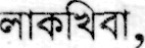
লাকখিবা,
